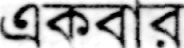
একবার
